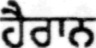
ਹੈਰਾਨ
